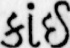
કાંઈ
